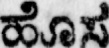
ಹೊಸ
